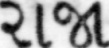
રાજા
